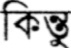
কিন্তু
